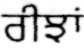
ਰੀਝਾਂ
